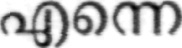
എന്നെ
